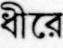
ধীরে
